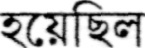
হয়েছিল
